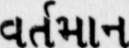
વર્તમાન
